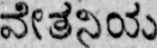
ವೇತನಿಯ
